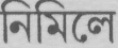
নিমিলে
